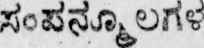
ಸಂಪನ್ಮೂಲಗಳ
